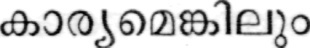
കാര്യമെങ്കിലും
